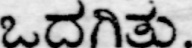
ಒದಗಿತು.
